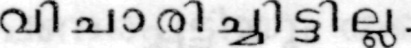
വിചാരിച്ചിട്ടില്ല.
